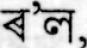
ৰ'ল,
